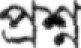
প্রশ্ন
